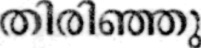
തിരിഞ്ഞു
